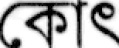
কোৎ
